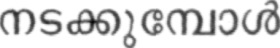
നടക്കുമ്പോള്‍
